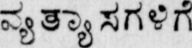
ವ್ಯತ್ಯಾಸಗಳಿಗೆ
